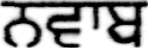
ਨਵਾਬ
